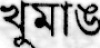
খুমাঙ
